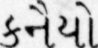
કનૈયો
